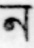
ন
